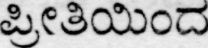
ಪ್ರೀತಿಯಿಂದ
